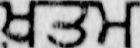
ਖ਼ਤਮ
